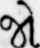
જો
